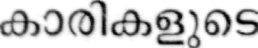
കാരികളുടെ
